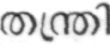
തന്ത്രി
